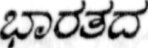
ಭಾರತದ
